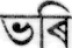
ভৰি
